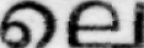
ലെ
